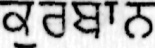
ਕੁਰਬਾਨ
